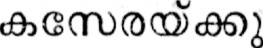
കസേരയ്ക്കു
